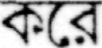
করে
